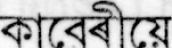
কাবেৰীয়ে
